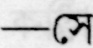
–সে
